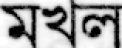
মখল
